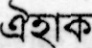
ঐহাক
